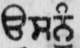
ਉਸਨੂੰ
